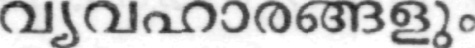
വ്യവഹാരങ്ങളും
